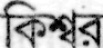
কিশ্বর
